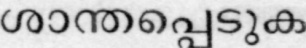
ശാന്തപ്പെടുക
